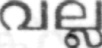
വല്ല
